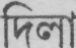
দিলা
